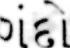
ગંદો
